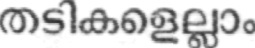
തടികളെല്ലാം
